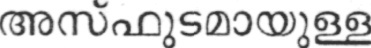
അസ്ഫുടമായുള്ള
